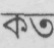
কত
